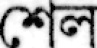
শেল
